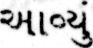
આવ્યું
